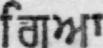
ਗਿਆ
